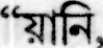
“য়ানি,
